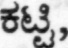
ಕಟ್ಟಿ,
